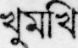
খুমখি
